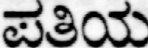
ಪತಿಯ
